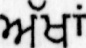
ਅੱਖਾਂ
